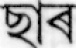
ছাৰ
